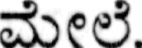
ಮೇಲೆ.
